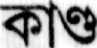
কাণ্ড
